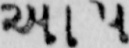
આપ
